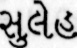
સુલેહ
